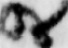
જ
